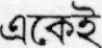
একেই
